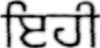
ਇਹੀ
